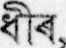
ধীৰ,
